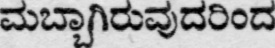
ಮಬ್ಬಾಗಿರುವುದರಿ೦ದ
